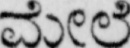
ಮೇಲೆ
